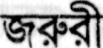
জরুরী
